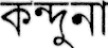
কন্দুনা
